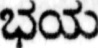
ಭಯ
